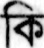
কি
